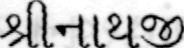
શ્રીનાથજી
